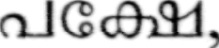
പക്ഷേ,
